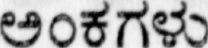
ಅಂಕಗಳು
